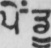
ਪੇਂਡੂ
